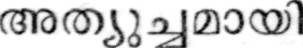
അത്യുച്ചമായി
